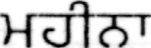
ਮਹੀਨਾ
